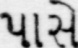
પાસે
